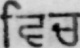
ਵਿਚ
